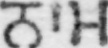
ਨਾਮ
